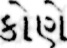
કોણે
